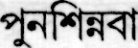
পুনশিন্নবা
